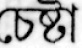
চেষ্টা
